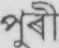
পুৰী
